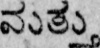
ಮತ್ತು
